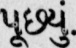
પૂછ્યું.
